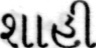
શાહી
